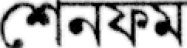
শেনফম
